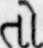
તો
